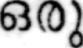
ഒരു
